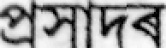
প্রসাদৰ
